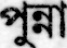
পুন্না
